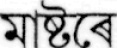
মাষ্টৰে
